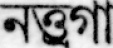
নত্ত্রগা
